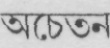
অচেতন
